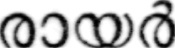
രായര്‍
